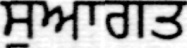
ਸੁਆਗਤ
